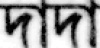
দাদা
